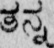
ತನ್ನ
